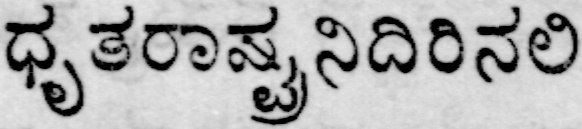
ಧೃತರಾಷ್ಟ್ರನಿದಿರಿನಲಿ
